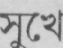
সুখে
